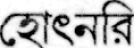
হোৎনরি
